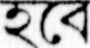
হবে
